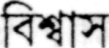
বিশ্বাস
